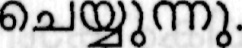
ചെയ്യുന്നു.
